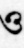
ও
